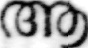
ആ
